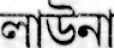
লাউনা
